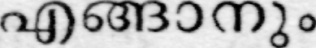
എങ്ങാനും
